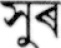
সুৰ
